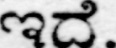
ಇದೆ.
